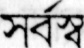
সর্বস্ব
